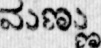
ಮಣ್ಣು
